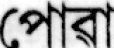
পোৱা
